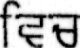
ਵਿਚ
